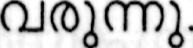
വരുന്നു.
